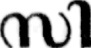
സി
